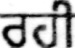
ਰਹੀ
